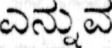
ಎನ್ನುವ
